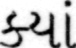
ક્યાં
